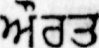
ਔਰਤ
